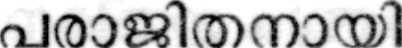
പരാജിതനായി
